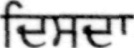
ਦਿਸਦਾ
